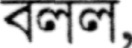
বলল,
